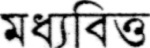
মধ্যবিত্ত
